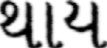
થાય
